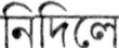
নিদিলে
